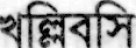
খল্লিবসি
